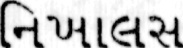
નિખાલસ
